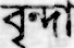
বৃন্দা
